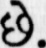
છે.
